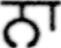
ਨਾ
